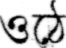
ওঠে
